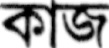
কাজ
